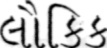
લૌકિક
